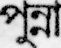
পুন্না
